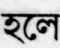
হলে
